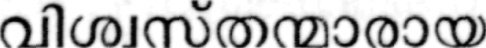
വിശ്വസ്തന്മാരായ
